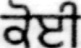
ਕੋਈ
